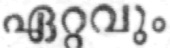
ഏറ്റവും
